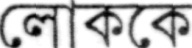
লোককে
